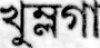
খুম্লগা
